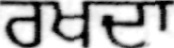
ਰਖਦਾ
